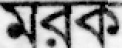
মরক
